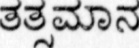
ತತ್ಸಮಾನ
